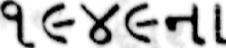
૧૯૪૯ના
